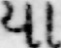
યા
